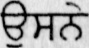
ਉਸਨੇ
